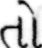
તો
